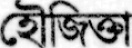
হৌজিক্তা
